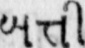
બત્તી
